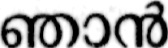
ഞാന്‍
